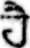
ਹੈ
